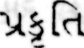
પ્રકૃતિ
